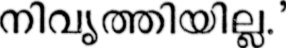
നിവൃത്തിയില്ല.’
